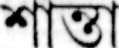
শান্তা
